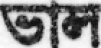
ভাল
